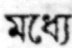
মধ্যে
